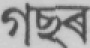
গছৰ
